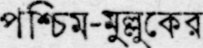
পশ্চিম-মুল্লুকের
